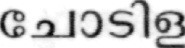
ചോടിള
